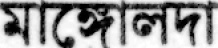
মাঙ্গোলদা
